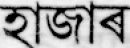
হাজাৰ
